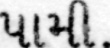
પામી.
